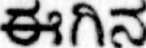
ಈಗಿನ
